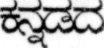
ಕನ್ನಡದ
